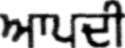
ਆਪਦੀ
